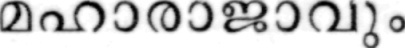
മഹാരാജാവും
